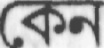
কেন
